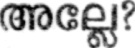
അല്ലേ?
